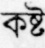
কষ্ট
